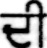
ਦੀ
